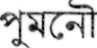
পুমনৌ
